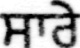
ਸਾਰੇ
